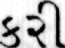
કરી
